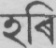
হৰি
